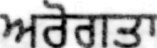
ਅਰੋਗਤਾ
